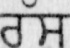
ਰੱਸ
